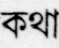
কথা
